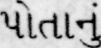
પોતાનું
